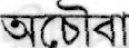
অচৌবা
